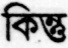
কিন্তু
